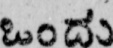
ಒಂದು
